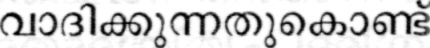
വാദിക്കുന്നതുകൊണ്ട്
